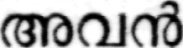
അവന്‍
